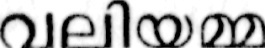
വലിയമ്മ
